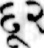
દૂર
